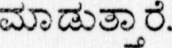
ಮಾಡುತ್ತಾರೆ.
